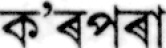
ক'ৰপৰা
